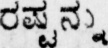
ರಷ್ಟನ್ನು
